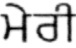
ਮੇਰੀ
